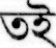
তই
